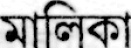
মালিকা
